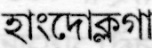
হাংদোক্লগা
